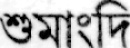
শুমাংদি
